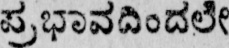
ಪ್ರಭಾವದಿಂದಲೇ
